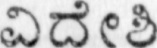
ವಿದೇಶಿ
